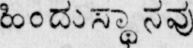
ಹಿಂದುಸ್ಥಾನವು
